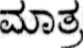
ಮಾತ್ರ
